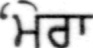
'ਮੇਰਾ
